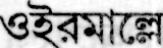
ওইরমাল্লে
